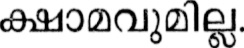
ക്ഷാമവുമില്ല.
